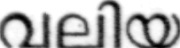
വലിയ
